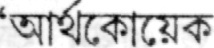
‘আর্থকোয়েক
